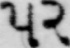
પર
